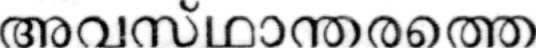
അവസ്ഥാന്തരത്തെ
